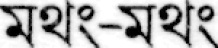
মথং-মথং
